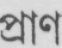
প্ৰাণ
